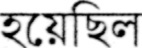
হয়েছিল
